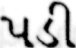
પડી
